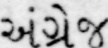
અંગ્રેજ
